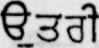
ਉਤਰੀ
